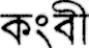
কংবী
